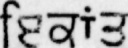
ਇਕਾਂਤ
